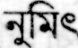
নুমিৎ
